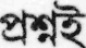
প্ৰশ্নই
